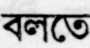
বলতে
